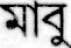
মাবু
